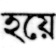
হয়ে
